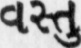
વસ્તુ
